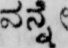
ವನ್ನೇ
